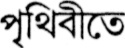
পৃথিবীতে
